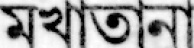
মখাতানা
